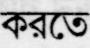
করতে
